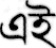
এই
